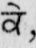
ਕੇ,
